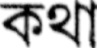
কথা
